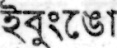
ইবুংঙো
